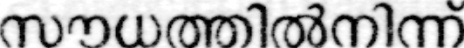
സൌധത്തില്‍നിന്ന്
